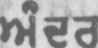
ਅੰਦਰ
